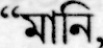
“মানি,
